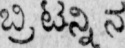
ಬ್ರಿಟನ್ನಿನ
